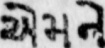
એમને
